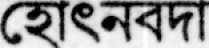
হোৎনবদা
